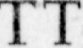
TT
